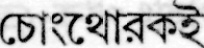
চোংথোরকই
